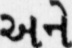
અને
